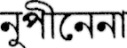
নুপীনেনা
